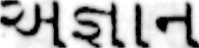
અજ્ઞાન
